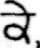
ਕੇ,
